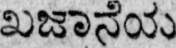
ಖಜಾನೆಯ
